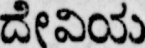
ದೇವಿಯ
